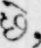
છે,
